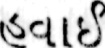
હવાઈ
